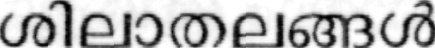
ശിലാതലങ്ങള്‍
